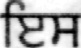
ਇਸ
